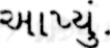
આપ્યું.
